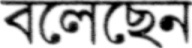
বলেছেন
